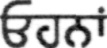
ਓਹਨਾਂ
